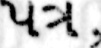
પત્ર,
